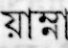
য়াম্না
